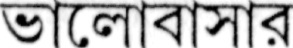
ভালোবাসার
